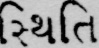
સ્થિતિ
